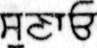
ਸੁਣਾਓ
